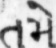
તમે
